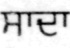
ਸਾਦਾ
